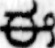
ಈ
